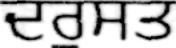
ਦਰੁਸਤ
